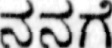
ನನಗೆ
